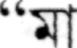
“মা
